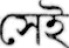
সেই
